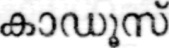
കാഡൂസ്
